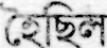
হৈছিল
